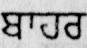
ਬਾਹਰ
